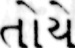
તોયે
